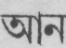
আন
